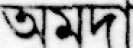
অমদা
